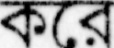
করে
